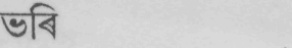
ভৰি
